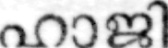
ഹാജി
